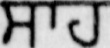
ਸਾਹ
